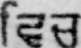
ਵਿਚ
